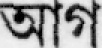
আগ
